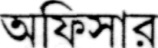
অফিসার
